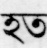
হত
